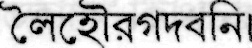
লৈহৌরগদবনি।
